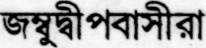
জম্বুদ্বীপবাসীরা
